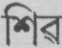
শিৱ
